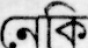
নেকি
